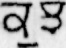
ਕੁਝ
